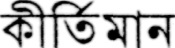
কীর্তিমান
